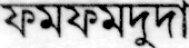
ফমফমদুদা
